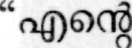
"എന്റെ
